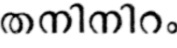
തനിനിറം
